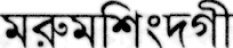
মরুমশিংদগী
